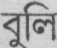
বুলি
